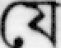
যে
